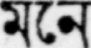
মনে
